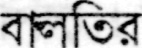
বালতির
